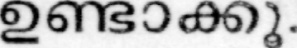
ഉണ്ടാക്കൂ.
